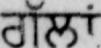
ਗੱਲਾਂ
